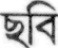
ছবি
